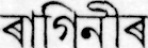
ৰাগিনীৰ
